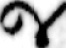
જ
